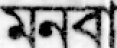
মনবা
